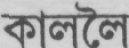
কাললৈ
